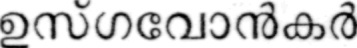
ഉസ്ഗവോന്‍കര്‍
